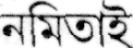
নমিতাই
